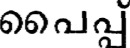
പൈപ്പ്
